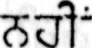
ਨਹੀਂ
